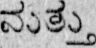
ಮತ್ತು
